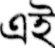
এই
